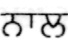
ਨਾਲ
